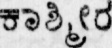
ಕಾಶ್ಮೀರ
